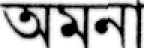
অমনা
